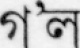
গ'ল
